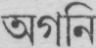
অগনি
